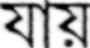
যায়
